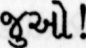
જુઓ!
